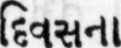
દિવસના
